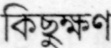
কিছুক্ষণ
